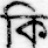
কি
